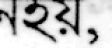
নহয়,
